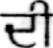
ਦੀ
